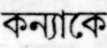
কন্যাকে
